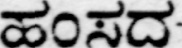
ಹಂಸದ
